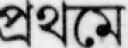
প্রথমে
